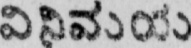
ವಿನಿಮಯ
